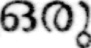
ഒരു
